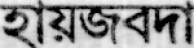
হায়জবদা
